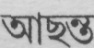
আছন্ত
